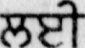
ਲਈ
